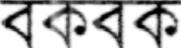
বকবক
